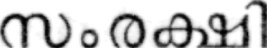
സംരക്ഷി
